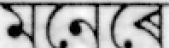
মনেৰে
